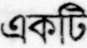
একটি
